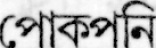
পোকপনি
